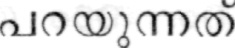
പറയുന്നത്
